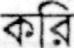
করি
